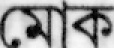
মোক
